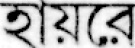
হায়রে
